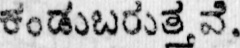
ಕಂಡುಬರುತ್ತವೆ.
